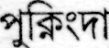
পুক্নিংদা
